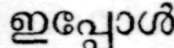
ഇപ്പോള്‍
